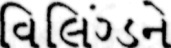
વિલિંગ્ડને
